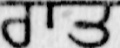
ਰਾਤ
